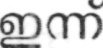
ഇന്ന്
